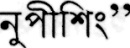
নুপীশিং”
